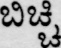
ಬಿಚ್ಚಿ
